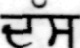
ਦੱਸ
